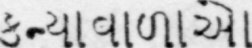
કન્યાવાળાઓ
